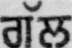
ਗੱਲ
